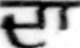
ਦਾ
